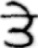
ਤੇ
